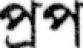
প্রপ
